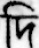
দি
